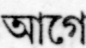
আগে
